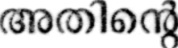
അതിന്റെ
